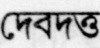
দেবদত্ত
